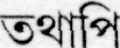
তথাপি
